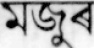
মজুৰ
